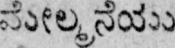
ಮೇಲ್ಮನೆಯು
